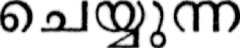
ചെയ്യുന്ന
